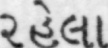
રહેલા
